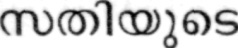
സതിയുടെ
